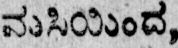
ಮಸಿಯಿಂದ,
